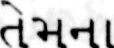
તેમના
